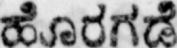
ಹೊರಗಡೆ
